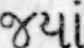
જ્યાં
